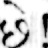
છે!
